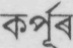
কর্পূৰ
